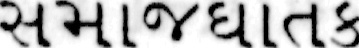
સમાજઘાતક
